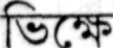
ভিক্ষে
